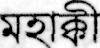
মহাক্কী
